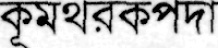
কূমথরকপদা
